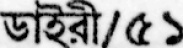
ডাইরী/৫১
